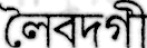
লৈবদগী
